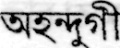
অহন্দুগী
